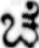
ಚೆ
